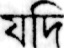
যদি
